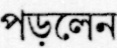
পড়লেন
